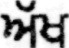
ਅੱਖ
